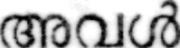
അവള്‍
